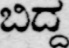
ಬಿದ್ದ
